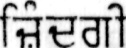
ਜ਼ਿੰਦਗੀ
